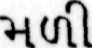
મળી
